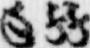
હક્ક
